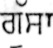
ਗੁੱਸਾ
